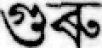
গুৰু
